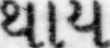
થાય
